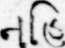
નહિ
